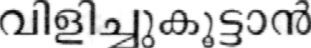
വിളിച്ചുകൂട്ടാന്‍
